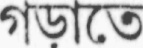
গড়াতে
